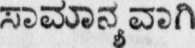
ಸಾಮಾನ್ಯವಾಗಿ
